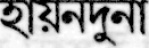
হায়নদুনা
